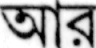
আর
